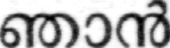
ഞാന്‍
